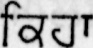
ਕਿਹਾ
